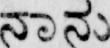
ನಾನು
